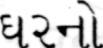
ધરનો
